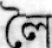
লৈ
